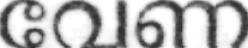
വേണ
